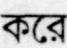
করে
